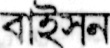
বাইসন
